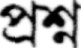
প্রশ্ন
